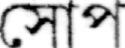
সোপ
